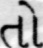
તો
